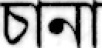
চানা
